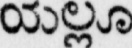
ಯಲ್ಲೂ
